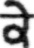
ਕੇ
